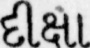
દીક્ષા
